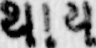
થાય
